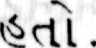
હતો.
